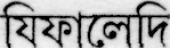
যিফালেদি
